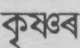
কৃষ্ণৰ
